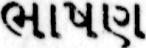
ભાષણ
